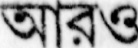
আরও
